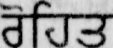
ਰੋਹਿਤ
